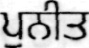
ਪੁਨੀਤ
